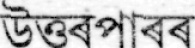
উত্তৰপাৰৰ
